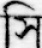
সি
